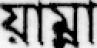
য়াম্না
